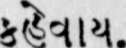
કહેવાય.
